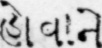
હોવાને
